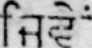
ਜਿਵੇਂ
